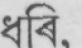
ধৰি,
